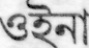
ওইনা
